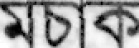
মচাক
